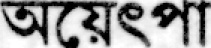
অয়েৎপা
